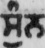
ਸੁੰਨ
